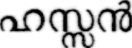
ഹസ്സന്‍
